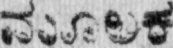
ಮೂಲಕ
